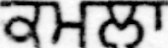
ਕਮਲਾ
